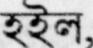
হইল,
